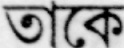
তাকে
